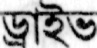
ড্রাইভ
